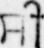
ਸੀ
